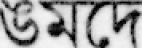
ঙমদে
